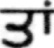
ਤਾਂ
